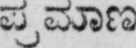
ಪ್ರಮಾಣ
